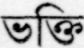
ভক্তি
